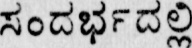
ಸಂದರ್ಭದಲ್ಲಿ
